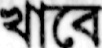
খাবে
